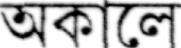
অকালে
